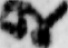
જ
